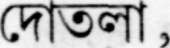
দোতলা,
